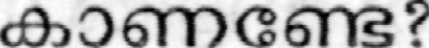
കാണണ്ടേ?
